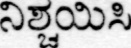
ನಿಶ್ಚಯಿಸಿ
